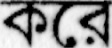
করে
